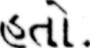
હતો.
